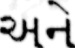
અને
